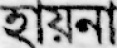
হায়না
